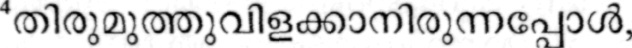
4തിരുമുത്തുവിളക്കാനിരുന്നപ്പോള്‍,
